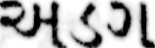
અડગ
